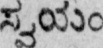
ಸ್ವಯಂ
